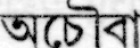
অচৌবা
